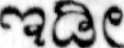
ಇಡೀ
